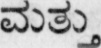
ಮತ್ತು
